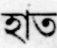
হাত
